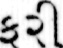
ફરી
